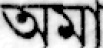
অমা
